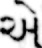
એ
